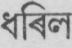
ধৰিল
